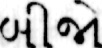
બીજો
